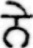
ਨੇ
